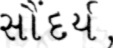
સૌંદર્ય,
